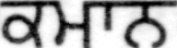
ਕਮਾਨ
